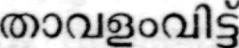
താവളംവിട്ട്
